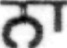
ਨਾ
